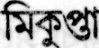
মিকু্প্তা
